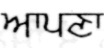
ਆਪਣਾ
